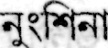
নুংশিনা
